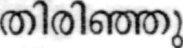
തിരിഞ്ഞു
